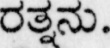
ರತ್ನನು.
